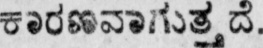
ಕಾರಣವಾಗುತ್ತದೆ.
